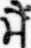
ਮੈਂ
